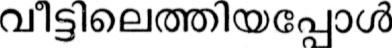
വീട്ടിലെത്തിയപ്പോള്‍
